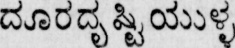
ದೂರದೃಷ್ಟಿಯುಳ್ಳ
